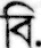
বি.
